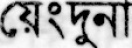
য়েংদুনা
